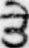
ਤੇ
